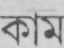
কাম
